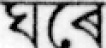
ঘৰে
